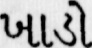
ખાડો
